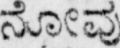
ನೋವು
